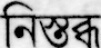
নিস্তব্ধ
